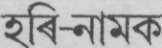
হৰি-নামক
